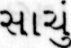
સાચું
